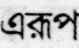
এরূপ
